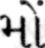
મોં
